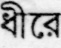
ধীরে
